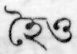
হৈও
